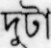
দুটা
